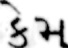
કેમ
